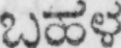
ಬಹಳ
